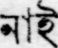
নাই
